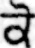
ਕੋ
